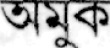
অমুক
